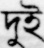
দুই
